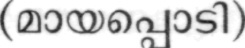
(മായപ്പൊടി)
